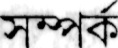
সম্পর্ক
